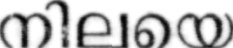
നിലയെ
